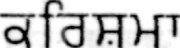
ਕਰਿਸ਼ਮਾ
